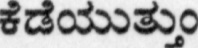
ಕೆಡೆಯುತ್ತುಂ
